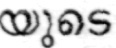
യുടെ
